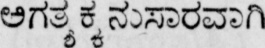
ಅಗತ್ಯಕ್ಕನುಸಾರವಾಗಿ
